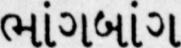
ભાંગબાંગ
